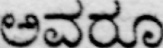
ಅವರೂ
